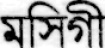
মসিগী
